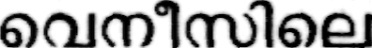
വെനീസിലെ
